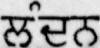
ਲੰਦਨ
